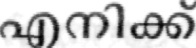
എനിക്ക്
